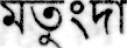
মতুংদা
